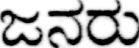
ಜನರು
